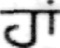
ਹਾਂ
